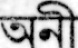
অনী
